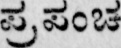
ಪ್ರಪಂಚ
